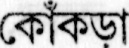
কোঁকড়া
